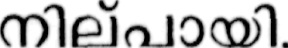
നില്പായി.
